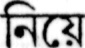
নিয়ে
